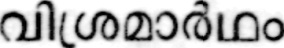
വിശ്രമാര്‍ഥം
